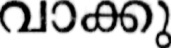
വാക്കു
